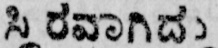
ಸ್ಥಿರವಾಗಿದು
